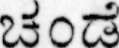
ಚಂಡೆ
